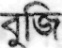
বুজি
